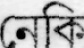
নেকি
